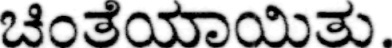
ಚಿಂತೆಯಾಯಿತು.
